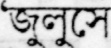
‘জুলুসে
